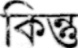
কিন্তু
